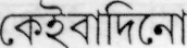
কেইবাদিনো
